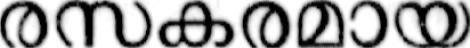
രസകരമായ
